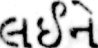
લઈને
